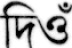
দিওঁ
